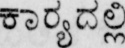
ಕಾರ್‍ಯದಲ್ಲಿ
